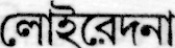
লোইরেদনা
